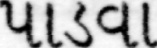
પાડવા
